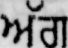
ਅੱਗ
